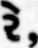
રે,
